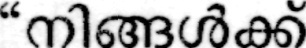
“നിങ്ങള്‍ക്ക്
